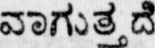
ವಾಗುತ್ತದೆ
